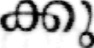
ക്കു
